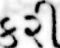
કરી
